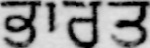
ਭਾਰਤ
